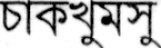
চাকখুমসু
